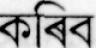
কৰিব
